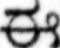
ಈ
